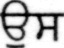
ਉਸ
